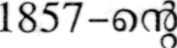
1857-ന്റെ
